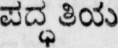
ಪದ್ಧತಿಯ
